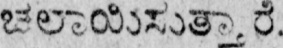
ಚಲಾಯಿಸುತ್ತಾರೆ.
